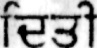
ਦਿਤੀ
